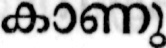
കാണു
